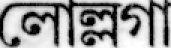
লোল্লগা
